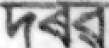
দৰৱ
